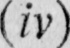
(iv)
